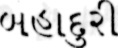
બહાદુરી
